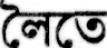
লৈতে
